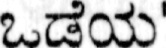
ಒಡೆಯ’
